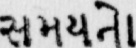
સમયનો
